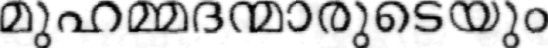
മുഹമ്മദന്മാരുടെയും
